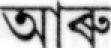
আৰু
